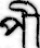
পী
